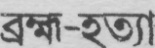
ব্ৰহ্ম-হত্যা
